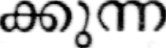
ക്കുന്ന
